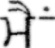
ਮੈਂ
